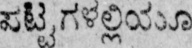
ಪಟ್ಟಿಗಳಲ್ಲಿಯೂ
